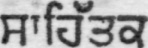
ਸਾਹਿੱਤਕ
